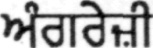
ਅੰਗਰੇਜ਼ੀ
